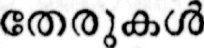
തേരുകള്‍
